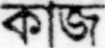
কাজ
